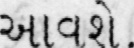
આવશે.
